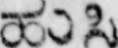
ಹುಸಿ
